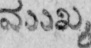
ಮುಖ್ಯ
